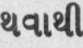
થવાથી
